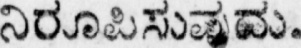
ನಿರೂಪಿಸುವುದು.
